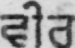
ਵੀਰ
